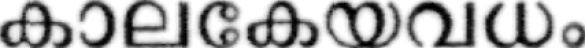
കാലകേയവധം
